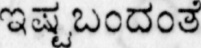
ಇಷ್ಟಬಂದಂತೆ
